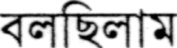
বলছিলাম
